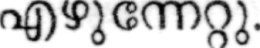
എഴുന്നേറ്റു.
